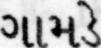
ગામડે
